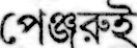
পেঞ্জরুই
